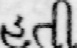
હતી
